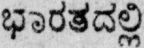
ಭಾರತದಲ್ಲಿ
